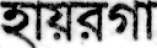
হায়রগা
